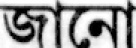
জানো
